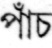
পাঁচ
